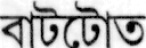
বাটটোত
